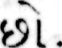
છો.
